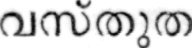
വസ്തുത
